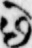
છે
